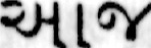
આજ
